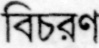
বিচরণ
